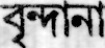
বৃন্দানা
